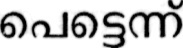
പെട്ടെന്ന്
